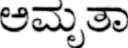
ಅಮೃತಾ
